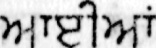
ਆਈਆਂ
